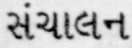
સંચાલન
